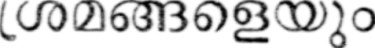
ശ്രമങ്ങളെയും
